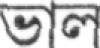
ভাল
